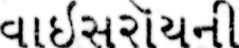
વાઇસરૉયની
